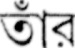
তাঁর
